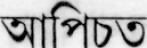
আপিচত
